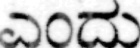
ಎಂದು
